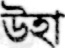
উহা
